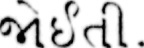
જોઇતી.
